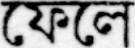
ফেলে
